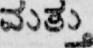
ಮತ್ತು
